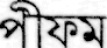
পীফম
